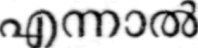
എന്നാല്‍
